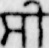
ਸੀ
